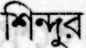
শিন্দুর
